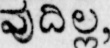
ವುದಿಲ್ಲ,
